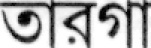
তারগা
